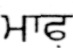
ਮਾਫ਼
